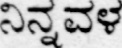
ನಿನ್ನವಳ
